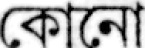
কোনো
